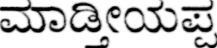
ಮಾಡ್ತೀಯಪ್ಪ
